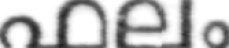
ഫലം
